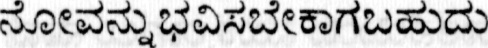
ನೋವನ್ನುಭವಿಸಬೇಕಾಗಬಹುದು
